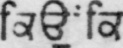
ਕਿਉਂਕਿ
